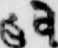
હવે
